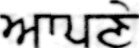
ਆਪਣੇ
